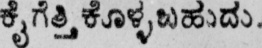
ಕೈಗೆತ್ತಿಕೊಳ್ಳಬಹುದು.
